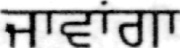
ਜਾਵਾਂਗਾ
